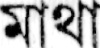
মাথা
